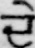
ਦੇ
